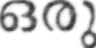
ഒരു
